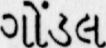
ગોંડલ
